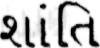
શાંતિ
